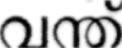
വന്ത്
